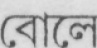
বোলে
